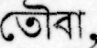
তৌবা,
